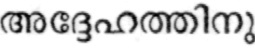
അദ്ദേഹത്തിനു
